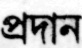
প্রদান
